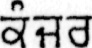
ਕੰਜਰ
